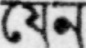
যেন
